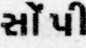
સોંપી
